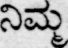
ನಿಮ್ಮ
